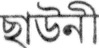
ছাউনী
